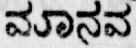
ಮಾನವ
